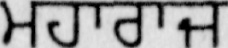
ਮਹਾਰਾਜ
